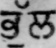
ਭੁੱਲ
